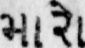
મારો
